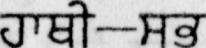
ਹਾਥੀ-ਸਭ
